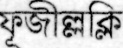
ফূজীল্লক্লি
